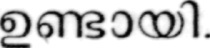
ഉണ്ടായി.
